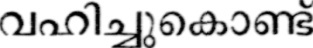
വഹിച്ചുകൊണ്ട്
